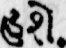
હશે.
